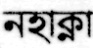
নহাক্না
